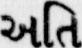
અતિ
